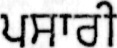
ਪਸਾਰੀ
